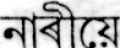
নাৰীয়ে
